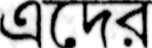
এদের
